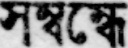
সম্বন্ধে
